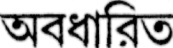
অবধারিত
